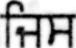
ਜਿਸ
